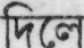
দিলে
